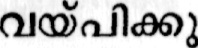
വയ്പിക്കു
